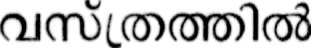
വസ്ത്രത്തില്‍
